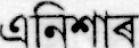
এনিশাৰ
